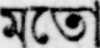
মতো
